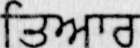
ਤਿਆਰ
